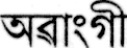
অৱাংগী
